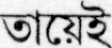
তায়েই
